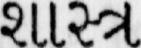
શાસ્ત્ર
